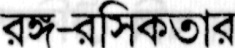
রঙ্গ-রসিকতার
